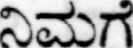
ನಿಮಗೆ
